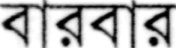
বারবার
